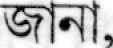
জানা,
